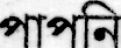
পাপনি
